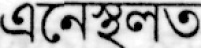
এনেস্হলত
